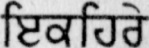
ਇਕਹਿਰੇ
